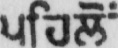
ਪਹਿਲੋਂ
